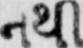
નથી
